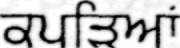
ਕਪੜਿਆਂ
